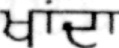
ਖਾਂਦਾ
